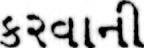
કરવાની
